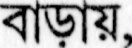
বাড়ায়,
